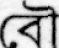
বৌ
